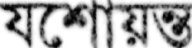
যশোয়ন্ত
